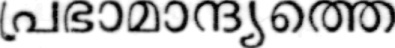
പ്രഭാമാന്ദ്യത്തെ
